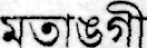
মতাঙগী
